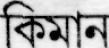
কিমান
